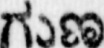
ಗುಣ
